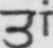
ਤਾਂ
